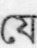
যে
